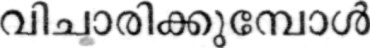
വിചാരിക്കുമ്പോള്‍
